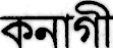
কনাগী
